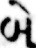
બે
